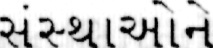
સંસ્થાઓને
